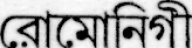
রোমোনিগী
